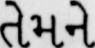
તેમને
